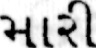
મારી
